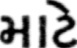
માટે
